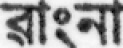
ৱাংনা
